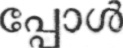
പ്പോള്‍
